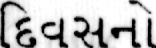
દિવસનો
